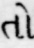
તો
